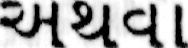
અથવા
